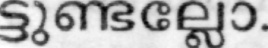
ട്ടുണ്ടല്ലോ.
